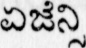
ಏಜೆನ್ಸಿ
